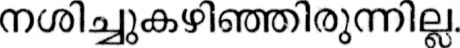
നശിച്ചുകഴിഞ്ഞിരുന്നില്ല.
